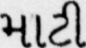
માટી
